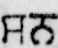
ਸਨ
